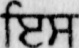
ਇਸ
